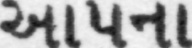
આપના
